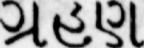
ગ્રહણ
